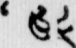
'હટ્
